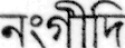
নংগীদি
